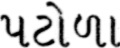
પટોળા
